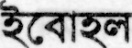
ইবোহল
